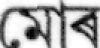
মোৰ
